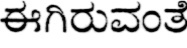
ಈಗಿರುವಂತೆ
